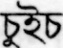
চুইচ
